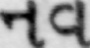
નવ
